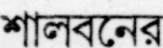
শালবনের
